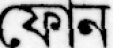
ফোন
